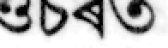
ওচৰত
